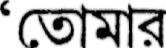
'তোমার
